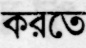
করতে
